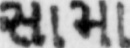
સામા
